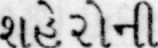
શહેરોની
